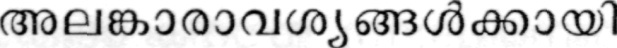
അലങ്കാരാവശ്യങ്ങള്‍ക്കായി
